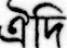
ঐদি
